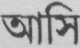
আসি
